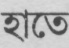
হাতে
